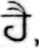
ਹੈ,
